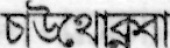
চাউথোক্নবা
